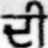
ਦੀ
